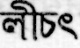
লীচৎ
